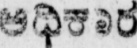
ಅಧಿಕಾರ
